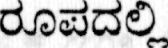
ರೂಪದಲ್ಲಿ
